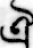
ঐ
